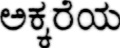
ಅಕ್ಕರೆಯ
